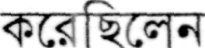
করেছিলেন
